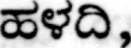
ಹಳದಿ,
